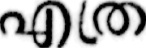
എത്ര
